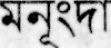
মনূংদা
